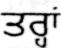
ਤਰ੍ਹਾਂ
